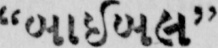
“બાઈબલ”
